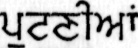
ਪੁਟਣੀਆਂ
